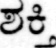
ಶಕ್ತಿ
